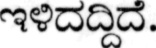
ಇಳಿದದ್ದಿದೆ.
